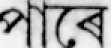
পাৰে
